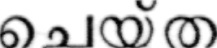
ചെയ്ത
